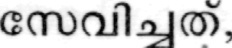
സേവിച്ചത്,
